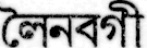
লৈনবগী
